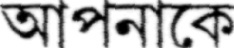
আপনাকে
